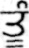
ਤੂੰ
